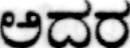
ಅದರ
